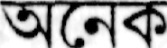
অনেক
